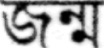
জন্ম
